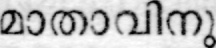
മാതാവിനു
